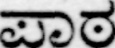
ಪಾಠ
